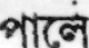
পালে
